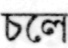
চলে
